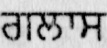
ਗਲਾਸ
